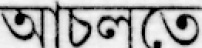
আচলতে
